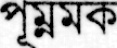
পূম্নমক
